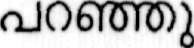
പറഞ്ഞു
